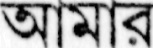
আমার
